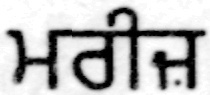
ਮਰੀਜ਼
